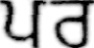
ਪਰ
